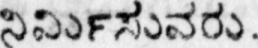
ನಿರ್ಮಿಸುವರು.
